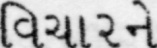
વિચારને
